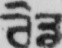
ਰੋਡ
